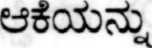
ಆಕೆಯನ್ನು
